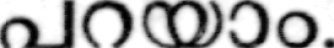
പറയാം.
